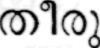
തീരു
